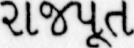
રાજપૂત
